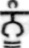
ਨੂੰ
